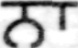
ਨਾ
